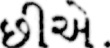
છીએ.
